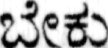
ಬೇಕು
